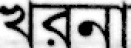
খরনা
